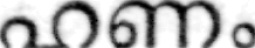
ഹണം
